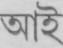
আই
